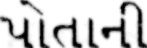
પોતાની
